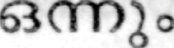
ഒന്നും
